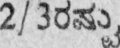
2/3ರಷ್ಟು
